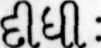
દીધી:
